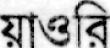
য়াওরি
